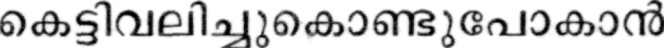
കെട്ടിവലിച്ചുകൊണ്ടുപോകാന്‍
